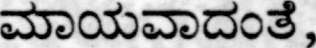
ಮಾಯವಾದಂತೆ,
